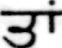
ਤਾਂ
